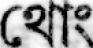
থোং
